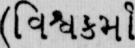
કર્યાં.(વિશ્વકર્મા
